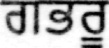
ਗਭਰੂ
